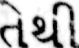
તેથી
